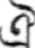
ঐ
